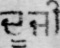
ਦੂਜੀ
